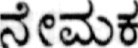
ನೇಮಕ
